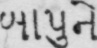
બાપુને
